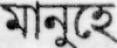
মানুহে
